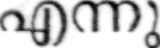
എന്നു
